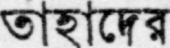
তাহাদের
